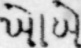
ખોબે
